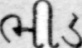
ભીડ
